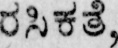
ರಸಿಕತೆ,
